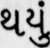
થયું
